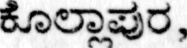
ಕೊಲ್ಲಾಪುರ,
